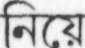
নিয়ে
